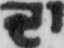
ਦਾ
